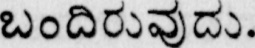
ಬಂದಿರುವುದು.
